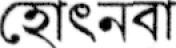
হোৎনবা
